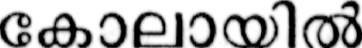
കോലായില്‍
